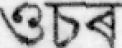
ওচৰ
